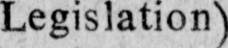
Legislation)
